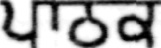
ਪਾਠਕ
